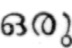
ഒരു
